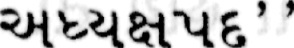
અધ્યક્ષપદ"
